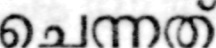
ചെന്നത്
